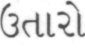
ઉતારો
